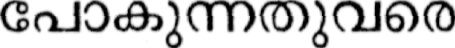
പോകുന്നതുവരെ
